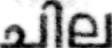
ചില
